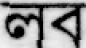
লব
